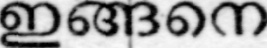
ഇങ്ങനെ
